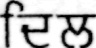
ਦਿਲ
